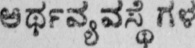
ಅರ್ಥವ್ಯವಸ್ಥೆಗಳ
